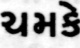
ચમકે
